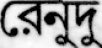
রেনুদু
